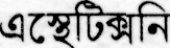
এস্থেটিক্সনি
